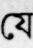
যে
